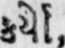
કર્યો,
